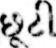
છૂટી
